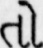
તો
